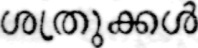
ശത്രുക്കള്‍
